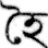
হৈ
